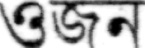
ওজন
